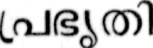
പ്രഭൃതി
